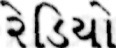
રેડિયો
